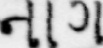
નાગ
